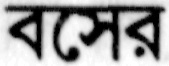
বসের
